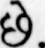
છે.
